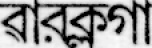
ৱারক্লগা
